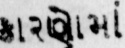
કારણોમાં
